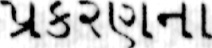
પ્રકરણના
